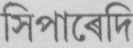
সিপাৰেদি
